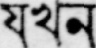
যখন
